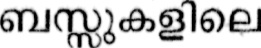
ബസ്സുകളിലെ
